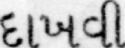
દાખવી
